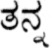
ತನ್ನ
